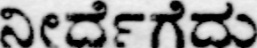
ನೀರ್ದೆಗೆದು
